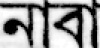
নাবা
